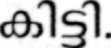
കിട്ടി.
